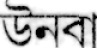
উনবা
